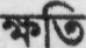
ক্ষতি
